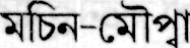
মচিন-মৌপ্বা
